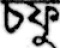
চফু
